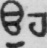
ਉਹ
